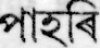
পাহৰি
